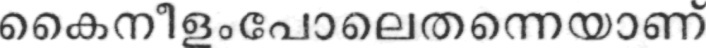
കൈനീളംപോലെതന്നെയാണ്
